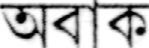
অবাক
